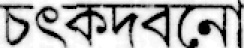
চৎকদবনো
